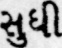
સુધી
